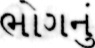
ભોગનું
